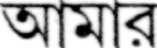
আমার
